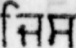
ਜਿਸ
